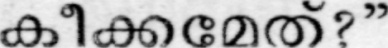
കീക്കമേത്?”
